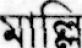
মাল্লি
